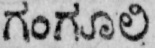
ಗಂಗೂಲಿ
